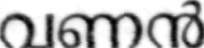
വണന്‍
